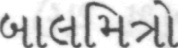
બાલમિત્રો
